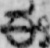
ಈ
